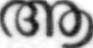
ആ
